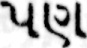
પણ
